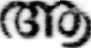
ആ
